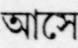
আসে
